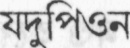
যদুপিওন
